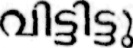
വിട്ടിട്ടു
